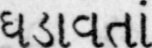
ઘડાવતાં
